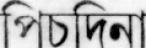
পিচদিনা
